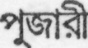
পুজারী
